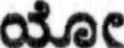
ಯೋ
